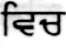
ਵਿਚ
